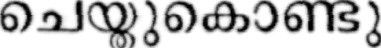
ചെയ്തുകൊണ്ടു
